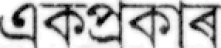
একপ্রকাৰ
